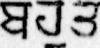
ਬਹੁਤ
